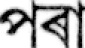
পৰা
